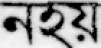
নহয়
